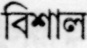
বিশাল
